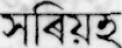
সৰিয়হ
